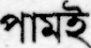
পামই
